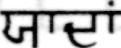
ਯਾਦਾਂ
